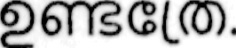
ഉണ്ടത്രേ.
